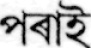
পৰাই
